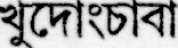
খুদোংচাবা
